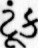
ટૂંક
